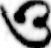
ও
